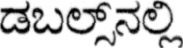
ಡಬಲ್ಸ್‌ನಲ್ಲಿ
